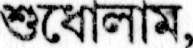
শুধোলাম,
